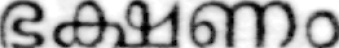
ഭക്ഷണം
